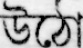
উঠো
